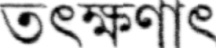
তত্ক্ষণাত্
